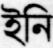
ইনি
